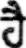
ਹੈ
